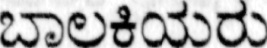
ಬಾಲಕಿಯರು
